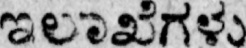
ಇಲಾಖೆಗಳು
